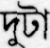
দুটা
